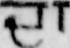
ਦਾ
